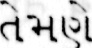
તેમણે
